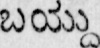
ಬಯ್ದು
